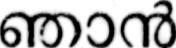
ഞാന്‍
